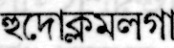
হুদোক্লমলগা
